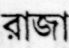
রাজা
